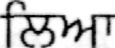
ਲਿਆ
